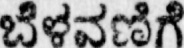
ಬೆಳವಣಿಗೆ
